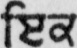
ਇਕ
